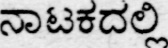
ನಾಟಕದಲ್ಲಿ
